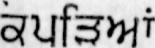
ਕਪੜਿਆਂ
